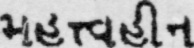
મહત્ત્વહીન
